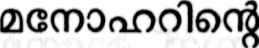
മനോഹറിന്റെ
